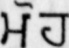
ਮੋਹ
